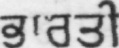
ਭਾਰਤੀ
